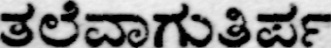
ತಲೆವಾಗುತಿರ್ಪ
